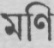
মণি
